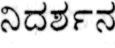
ನಿದರ್ಶನ
